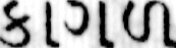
કાગળ
